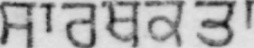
ਸਾਰਥਕਤਾ
